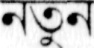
নতুন
